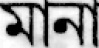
মানা
